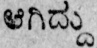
ಆಗಿದ್ದು
